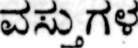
ವಸ್ತುಗಳ
